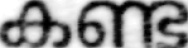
കണ്ട
